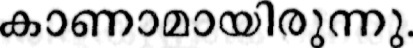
കാണാമായിരുന്നു.
